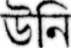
উনি
